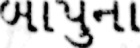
બાપુના
